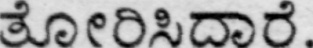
ತೋರಿಸಿದಾರೆ.
